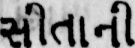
સીતાની
